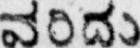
ವರಿದು
